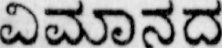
ವಿಮಾನದ
